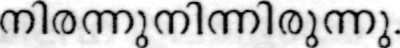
നിരന്നുനിന്നിരുന്നു.
